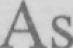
As
